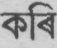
কৰি
